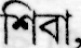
শিবা,
